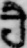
ਹੈ
